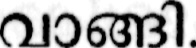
വാങ്ങി.
